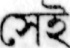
সেই
